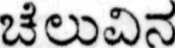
ಚೆಲುವಿನ
